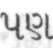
પણ
